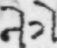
નેત્રે
